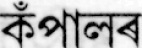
কঁপালৰ
